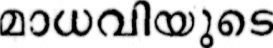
മാധവിയുടെ
